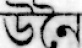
উনৈ
